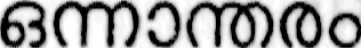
ഒന്നാന്തരം
